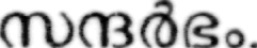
സന്ദര്‍ഭം.
